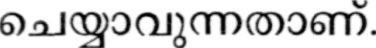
ചെയ്യാവുന്നതാണ്.
